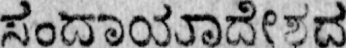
ಸಂದಾಯಾದೇಶದ
